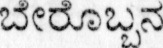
ಬೇರೊಬ್ಬನ
